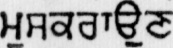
ਮੁਸਕਰਾਉਣ
